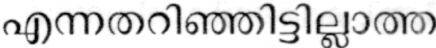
എന്നതറിഞ്ഞിട്ടില്ലാത്ത
